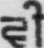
ਵੀ
